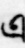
এ
